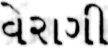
વેરાગી
